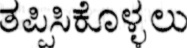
ತಪ್ಪಿಸಿಕೊಳ್ಳಲು
